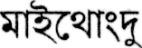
মাইথোংদু
